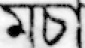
মচা
